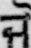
ਜੋ
